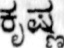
ಕೃಷ್ಣ
